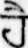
ਹੈ
